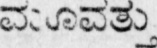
ಮೂವತ್ತು
